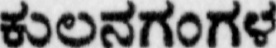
ಕುಲನಗಂಗಳ
